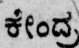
ಕೇಂದ್ರ
